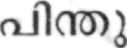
പിന്തു
